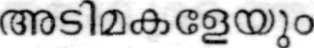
അടിമകളേയും
